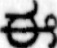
ಈ
